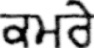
ਕਮਰੇ
